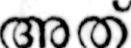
അത്
